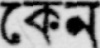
কেন
